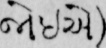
જોઈએ)
